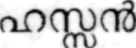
ഹസ്സന്‍
